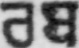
ਰਬ
